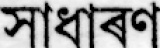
সাধাৰণ
